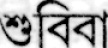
শুবিবা
